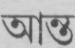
আন্ত
